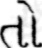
તો
